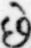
છે
